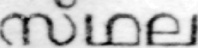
സ്ഥല
